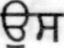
ਉਸ
